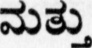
ಮತ್ತು
